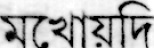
মখোয়দি
